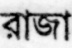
রাজা
